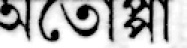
অতোপ্পা
